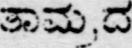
ತಾಮ್ರದ
